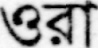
ওরা
